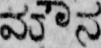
ಮೌನ
